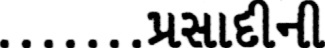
............પ્રસાદીની
